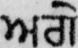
ਅਗੇ
